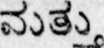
ಮತ್ತು
